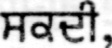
ਸਕਦੀ,
